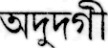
অদুদগী
